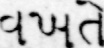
વખતે
